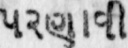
પરણાવી
